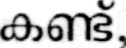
കണ്ട്,
